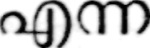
എന്ന
